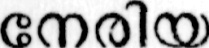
നേരിയ
